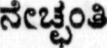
ನೇಚ್ಛಂತಿ
